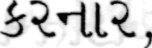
કરનાર,
